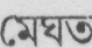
মেঘত
